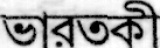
ভারতকী
